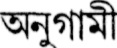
অনুগামী
